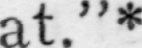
at."*
